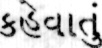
કહેવાતું
